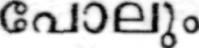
പോലും
